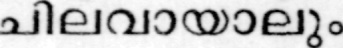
ചിലവായാലും
